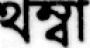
থম্বা
